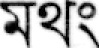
মথং
